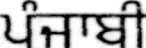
ਪੰਜਾਬੀ
